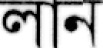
লান
